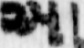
આ
